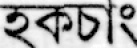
হকচাং
